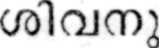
ശിവനു
